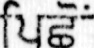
ਪਿਛੋਂ
